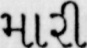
મારી
